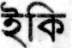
ইকি
